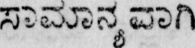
ಸಾಮಾನ್ಯವಾಗಿ
